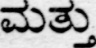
ಮತ್ತು
